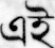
এই
